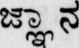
ಜ್ಞಾನ
